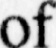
of
